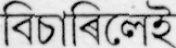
বিচাৰিলেই
